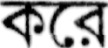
করে
